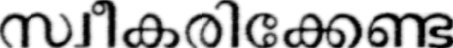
സ്വീകരിക്കേണ്ട
